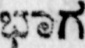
ಭಾಗ
